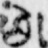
છો
